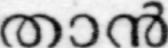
താന്‍
